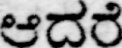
ಆದರೆ
